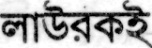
লাউরকই
